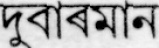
দুবাৰমান
